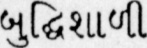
બુદ્ધિશાળી
